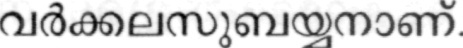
വര്‍ക്കലസുബയ്യനാണ്.
